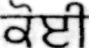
ਕੋਈ
